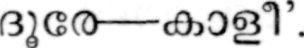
ദൂരേ-കാളീ'.
